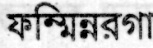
ফম্মিন্নরগা
